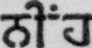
ਨੀਂਹ
